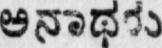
ಅನಾಥರು
